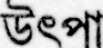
উৎপা
